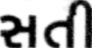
સતી
